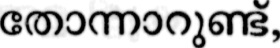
തോന്നാറുണ്ട്,
